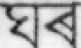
ঘৰ
